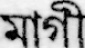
মাগী
